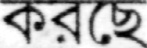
করছে
